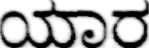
ಯಾರ
